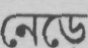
নেড়ে
